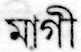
মাগী
